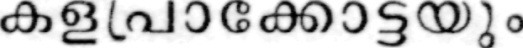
കളപ്രാക്കോട്ടയും
